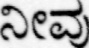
ನೀವು
